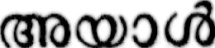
അയാള്‍
